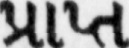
પ્રાપ્ત
